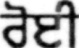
ਰੋਈ
